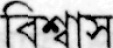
বিশ্বাস
